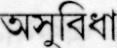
অসুবিধা
